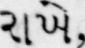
રાખે,
